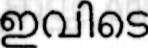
ഇവിടെ
